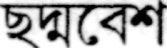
ছদ্মবেশ
